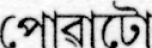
পোৱাটো
